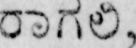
ರಾಗಲಿ,
